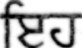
ਇਹ
